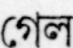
গেল
